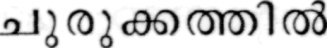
ചുരുക്കത്തില്‍
